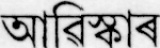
আৱিস্কাৰ
